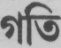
গতি
